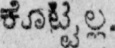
ಕೊಟ್ಟಿಲ್ಲ.
